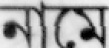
নামে
